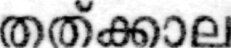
തത്ക്കാല
